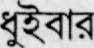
ধুইবার
